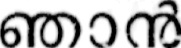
ഞാന്‍
